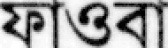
ফাওবা
